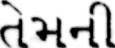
તેમની
